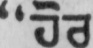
''ਹੋਰ
